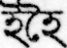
ইহৈ
